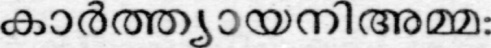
കാര്‍ത്ത്യായനിഅമ്മ:
